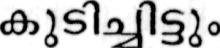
കുടിച്ചിട്ടും
